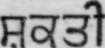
ਸ਼ਕਤੀ
